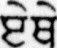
ਏਥੇ
